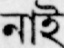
নাই
